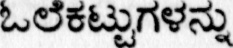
ಓಲೆಕಟ್ಟುಗಳನ್ನು
